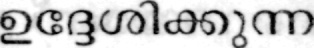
ഉദ്ദേശിക്കുന്ന
